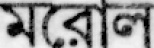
মরোল
